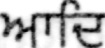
ਆਦਿ
